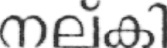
നല്കി
